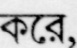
করে,
